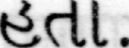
હતા.
